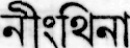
নীংথিনা
